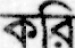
করি
